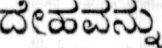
ದೇಹವನ್ನು
